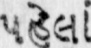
પહેલાં
